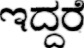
ಇದ್ದರೆ
